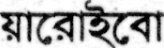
য়ারোইবো
